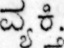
ವ್ಯಕ್ತಿ.
